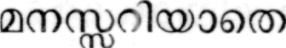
മനസ്സറിയാതെ
